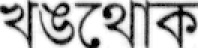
খঙথোক
